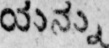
ಯನ್ನು
